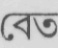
বেত
